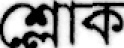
শ্লোক
